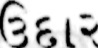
ઉદાર
